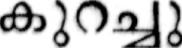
കുറച്ചു
